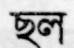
ছল
